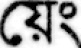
য়েং
